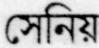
সেনিয়
